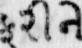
ફરીને
